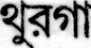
থুরগা
